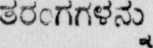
ತರಂಗಗಳನ್ನು
